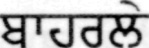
ਬਾਹਰਲੇ
